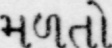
મળતો
